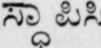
ಸ್ಥಾಪಿಸಿ
